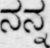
ನನ್ನ
